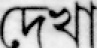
দেখা
